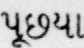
પૂછયા
